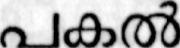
പകല്‍
